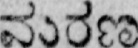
ಮರಣ
